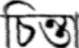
চিন্তা
